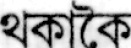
থকাকৈ
